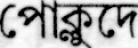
পোক্লুদে
